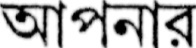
আপনার
